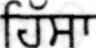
ਹਿੱਸਾ
